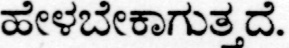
ಹೇಳಬೇಕಾಗುತ್ತದೆ.
